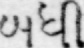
બધી
